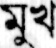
মুখ
